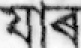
যাৰ
